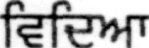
ਵਿਦਿਆ
